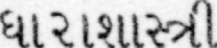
ધારાશાસ્ત્રી
